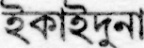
ইকাইদুনা
